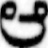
ಆ
